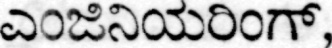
ಎಂಜಿನಿಯರಿಂಗ್,
